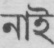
নাই
